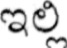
ಇಲ್ಲಿ
